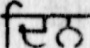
ਦਿਨ
